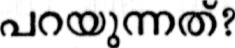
പറയുന്നത്?
